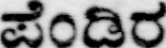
ಪೆಂಡಿರ
